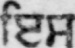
ਇਸ
